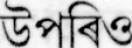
উপৰিও
